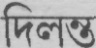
দিলন্ত
